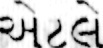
એટલે
